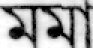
মমা
